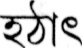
হঠাত্
